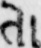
તો
